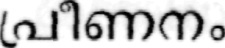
പ്രീണനം
